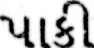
પાકી
